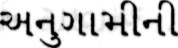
અનુગામીની
